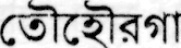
তৌহৌরগা
